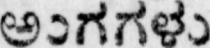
ಅಂಗಗಳು
